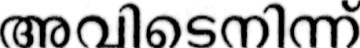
അവിടെനിന്ന്
